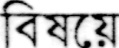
বিষয়ে
